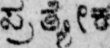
ಪ್ರತ್ಯೇಕ
